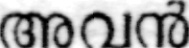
അവന്‍
